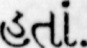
હતાં.
